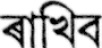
ৰাখিব
